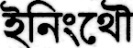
ইনিংথৌ
